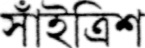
সাঁইত্রিশ
